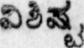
ವಿಶಿಷ್ಟ
